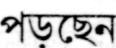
পড়ছেন
